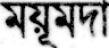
ময়ূমদা
